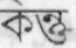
কিন্তু
